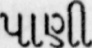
પાણી
